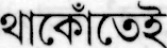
থাকোঁতেই
